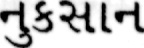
નુકસાન
